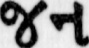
જન
